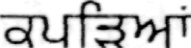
ਕਪੜਿਆਂ
